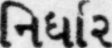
નિર્ધાર
